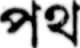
পথ
